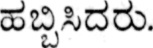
ಹಬ್ಬಿಸಿದರು.
